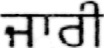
ਜਾਰੀ
